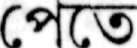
পেতে
